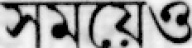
সময়েও
